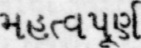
મહત્વપૂર્ણ
